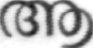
ആ
